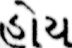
હોય
